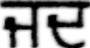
ਜਦ
